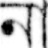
না
